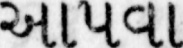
આપવા
